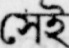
সেই
